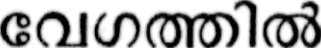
വേഗത്തില്‍
